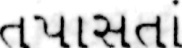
તપાસતાં
